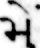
મેં
